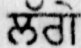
ਲੱਗੇ
